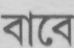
বাবে
